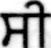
ਸੀ
